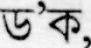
ড'ক,
